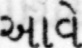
આવે
